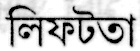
লিফটতা
